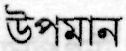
উপমান
